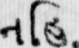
નહિ.
